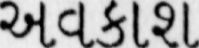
અવકાશ
